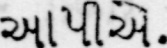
આપીએ.
